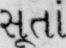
સૂતાં
